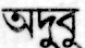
অদুবু
